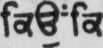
ਕਿਉਂਕਿ
